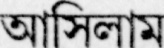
আসিলাম
